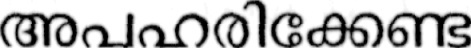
അപഹരിക്കേണ്ട
